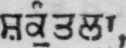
ਸ਼ਕੁੰਤਲਾ,
